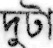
দুটা
